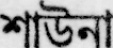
শাউনা
